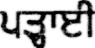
ਪੜ੍ਹਾਈ
